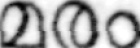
മരം
